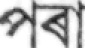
পৰা
